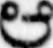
ಆ
